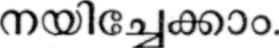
നയിച്ചേക്കാം.
